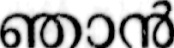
ഞാന്‍
